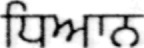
ਧਿਆਨ
